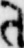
તે
